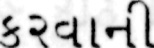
કરવાની
